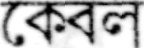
কেবল
